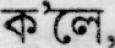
ক'লে,
